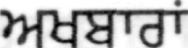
ਅਖਬਾਰਾਂ
